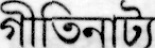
গীতিনাট্য
